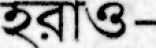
হরাও-
